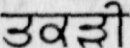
ਤਕੜੀ
